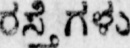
ರಸ್ತೆಗಳು
